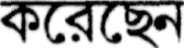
করেছেন
